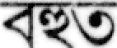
বহুত
